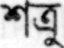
শত্রু
